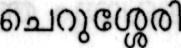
ചെറുശ്ശേരി
